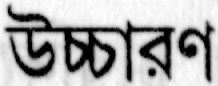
উচ্চারণ
